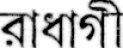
রাধাগী
